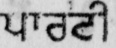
ਪਾਰਟੀ
